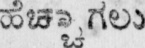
ಹೆಚ್ಚಾಗಲು
